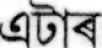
এটাৰ
